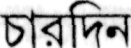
চারদিন
